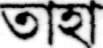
তাহা
